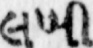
લખી
